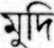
মুদি
